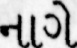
નાગે
